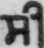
ਸੀ
